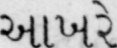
આખરે
